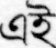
এই
